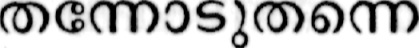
തന്നോടുതന്നെ
